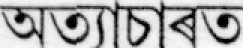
অত্যাচাৰত
